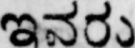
ಇವರು
